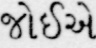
જોઈએ
